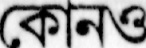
কোনও
